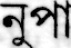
নুপা
